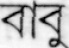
বাবু
